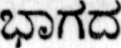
ಭಾಗದ
